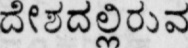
ದೇಶದಲ್ಲಿರುವ
